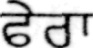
ਫੇਰਾ
